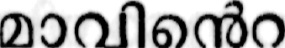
മാവിന്റെ
